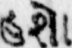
હશો
